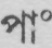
পা
